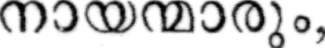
നായന്മാരും,
